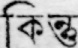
কিন্তু
